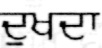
ਦੁਖਦਾ
